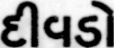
દીવડો
